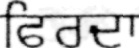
ਫਿਰਦਾ
